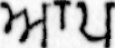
ਆਪ
